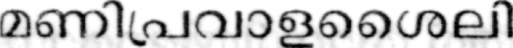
മണിപ്രവാളശൈലി
